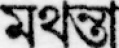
মথন্তা
